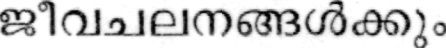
ജീവചലനങ്ങള്‍ക്കും
